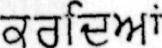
ਕਰਦਿਆਂ
